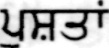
ਪੁਸ਼ਤਾਂ
